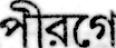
পীরগে
